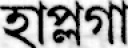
হাপ্লগা
